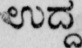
ಉದ್ದ
